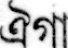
ঐগা
